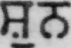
ਸ਼ੁਨ
